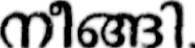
നീങ്ങി.
